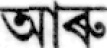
আৰু
